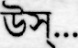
উস্...
